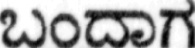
ಬಂದಾಗ
